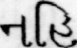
નહિ
